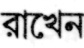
রাখেন
